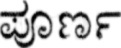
ಪೂರ್ಣ
